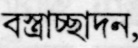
বস্ত্রাচ্ছাদন,
